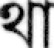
থা
